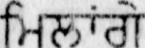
ਮਿਲਾਂਗੇ
